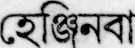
হেঞ্জিনবা
